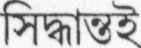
সিদ্ধান্তই
